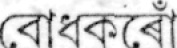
বোধকৰোঁ
